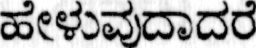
ಹೇಳುವುದಾದರೆ
